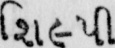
શિલ્પી
